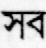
সব
